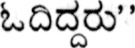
ಓದಿದ್ದರು"
